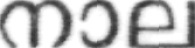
നാല
